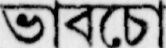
ভাবচো
